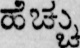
ಹೆಚ್ಚು
